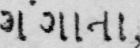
ગંગાના,
